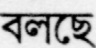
বলছে
